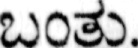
ಬಂತು.
